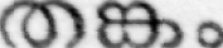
തങ്കം
